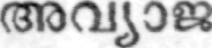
അവ്യാജ
